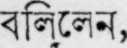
বলিলেন,
